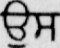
ਉਸ
